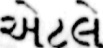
એટલે
